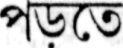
পড়তে
